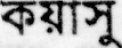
কয়াসু
